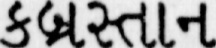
કબ્રસ્તાન
